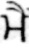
ਮੈਂ
